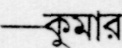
–কুমার
